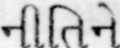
નીતિને
